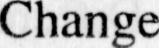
Change
